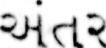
અંતર
